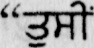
''ਤੁਸੀਂ
